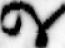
જ
